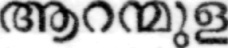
ആറന്മുള
